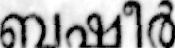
ബഷീര്‍
